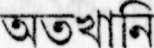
অতখানি
